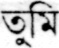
তুমি
